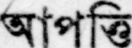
আপত্তি
